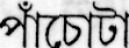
পাঁচোটা
